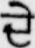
ਦੇ
